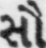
સૌ
